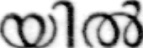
യില്‍
